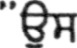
''ਉਸ
